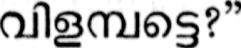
വിളമ്പട്ടെ?”
